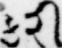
કરી
